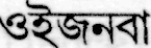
ওইজনবা
